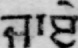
ਜਾਏ
